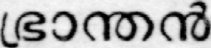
ഭ്രാന്തന്‍
